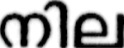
നില
